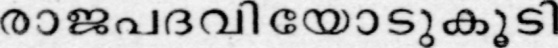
രാജപദവിയോടുകൂടി
